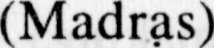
(Madras)
